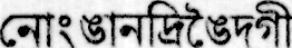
নোংঙানদ্রিঙৈদগী
